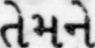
તેમને
